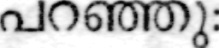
പറഞ്ഞു:
